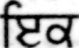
ਇਕ
